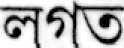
লগত
